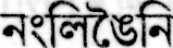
নংলিঙৈনি
